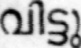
വിട്ടു
